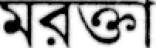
মরক্তা
